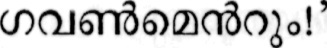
ഗവണ്‍മെൻറും!'
